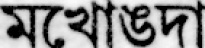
মখোঙদা
